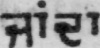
ਜਾਂਦਾ
